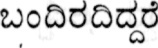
ಬಂದಿರದಿದ್ದರೆ
